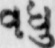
વધુ
